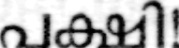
പക്ഷി!
